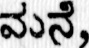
ಮನೆ,
